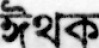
ঈথক
